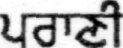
ਪਰਾਣੀ
